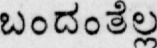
ಬಂದಂತೆಲ್ಲ
